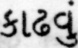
કાઢવું
